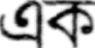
এক
